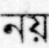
নয়
